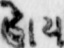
હોય
